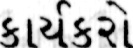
કાર્યકરો
